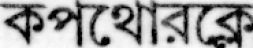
কপথোরক্লে
